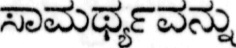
ಸಾಮರ್ಥ್ಯವನ್ನು
